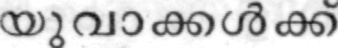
യുവാക്കള്‍ക്ക്
